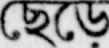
ছেড়ে
